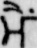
ਮੈਂ
